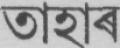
তাহাৰ
